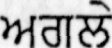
ਅਗਲੇ
